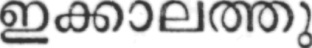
ഇക്കാലത്തു
